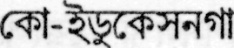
কো-ইডুকেসনগা
